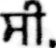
ਸੀ,
